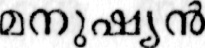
മനുഷ്യന്‍
